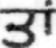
ਤਾਂ
